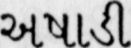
અષાડી
